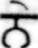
ਨੇ
